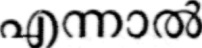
എന്നാല്‍
